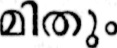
മിതും
